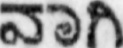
ವಾಗಿ
